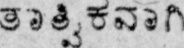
ತಾತ್ವಿಕವಾಗಿ
